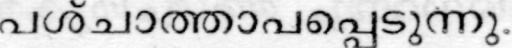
പശ്ചാത്താപപ്പെടുന്നു.
